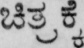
ಚಿತ್ರಕ್ಕೆ
